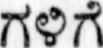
ಗಳಿಗೆ
